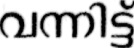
വന്നിട്ട്
